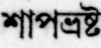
শাপভ্রষ্ট
